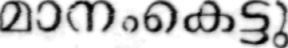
മാനംകെട്ടു
